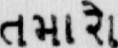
તમારો
